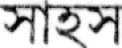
সাহস
